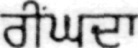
ਰੀਂਘਦਾ
